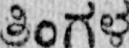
ತಿಂಗಳ
